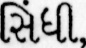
સિંધી,
